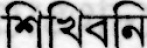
শিখিবনি
